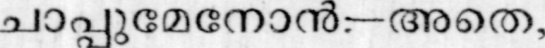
ചാപ്പുമേനോന്‍:-അതെ,
